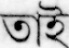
তাই
